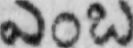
ಎಂಬ
